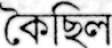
কৈছিল
